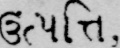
ઉત્પત્તિ,
